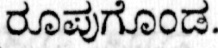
ರೂಪುಗೊಂಡ.
